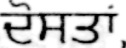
ਦੋਸਤਾਂ,
